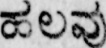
ಹಲವು
